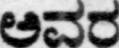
ಅವರ
